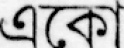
একো
